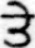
ਤੇ
